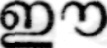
ഈ
